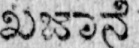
ಖಜಾನೆ
